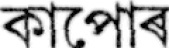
কাপোৰ
